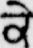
ਕੇ
